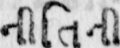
નીતિની
